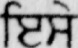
ਇਸੇ
